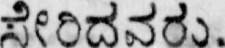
ಸೇರಿದವರು.
